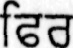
ਫਿਰ
